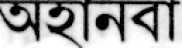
অহানবা
